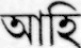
আহি
